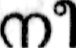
നീ
